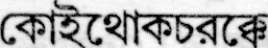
কোইথোকচরক্কে
